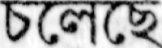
চলেছে
